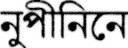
নুপীনিনে
